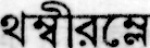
থম্বীরম্লে
